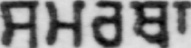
ਸਮਰਥਾ
